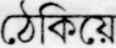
ঠেকিয়ে
